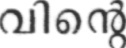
വിന്റെ
